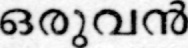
ഒരുവന്‍
